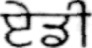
ਏਡੀ
